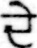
ਦੇ
